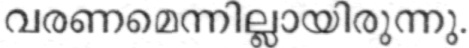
വരണമെന്നില്ലായിരുന്നു.
